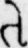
તે
